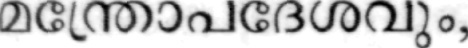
മന്ത്രോപദേശവും,
